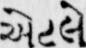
એટલે
